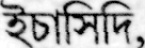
ইচাসিদি,
